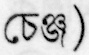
চেঞ্জ)
